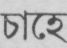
চাহে
